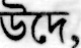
উদে,
